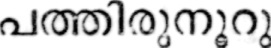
പത്തിരുനൂറു
